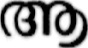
ആ
